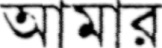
আমার
